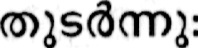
തുടര്‍ന്നു:
